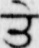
ਤੇ
